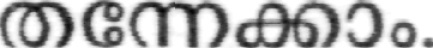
തന്നേക്കാം.
